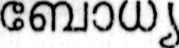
ബോധ്യ
